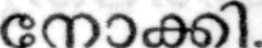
നോക്കി.
